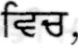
ਵਿਚ,
